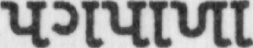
પગપાખા
